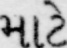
માટે
